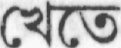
খেতে
